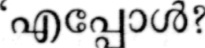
'എപ്പോള്‍?
